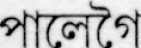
পালেগৈ
